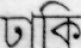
ঢাকি
